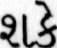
શકે
